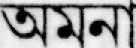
অমনা
